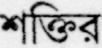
শক্তির
